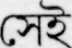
সেই
